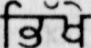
ਭਿੱਖੇ
